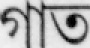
গাত
